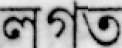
লগত
